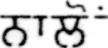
ਨਾਲੋਂ
